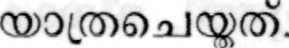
യാത്രചെയ്തത്.
